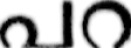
പറ
